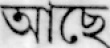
আছে
